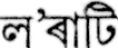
ল'ৰাটি
